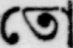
তো
